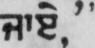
ਜਾਏ,''
